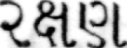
રક્ષણ
